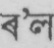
ৰ'ল
